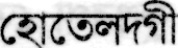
হোতেলদগী
